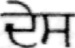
ਦੇਸ
